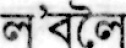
ল'বলৈ
